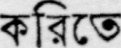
করিতে
